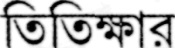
তিতিক্ষার
